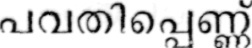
പവതിപ്പെണ്ണ്
